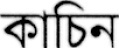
কাচিন
